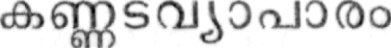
കണ്ണടവ്യാപാരം
